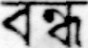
বন্ধ
